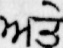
ਅਤੇ
